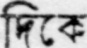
দিকে
